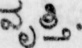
ವೃತ್ತಿ.
